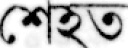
শেহত
